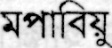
মপাবিয়ু
